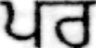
ਪਰ
